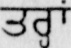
ਤਰ੍ਹਾਂ
